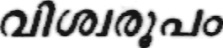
വിശ്വരൂപം
